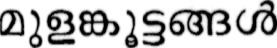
മുളങ്കൂട്ടങ്ങള്‍
